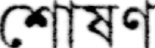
শোষণ
